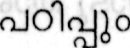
പഠിപ്പും
